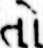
તો
